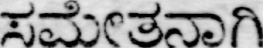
ಸಮೇತನಾಗಿ
